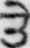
ਤੇ
